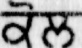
ਕੋਲ
